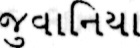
જુવાનિયા
